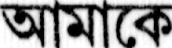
আমাকে
